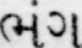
ભંગ
